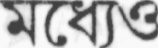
মধ্যেও
